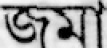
জমা
